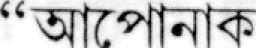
"আপোনাক
